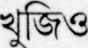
খুজিও
